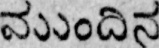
ಮುಂದಿನ
